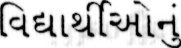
વિધાર્થીઓનું
